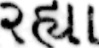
રહ્યા
